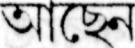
আছেন
